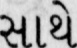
સાથે
